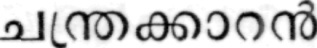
ചന്ത്രക്കാറന്‍
